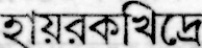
হায়রকখিদ্রে
